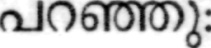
പറഞ്ഞു:
